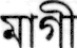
মাগী
